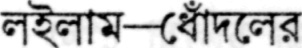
লইলাম—ধোঁদলের
